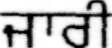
ਜਾਰੀ
